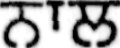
ਨਾਲ
